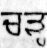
ਚੜ੍ਹ
